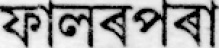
ফালৰপৰা
